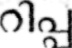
റിപ്പ
